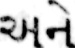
અને
